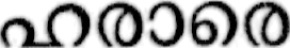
ഹരാരെ
